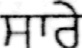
ਸਾਰੇ
